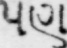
પણ
